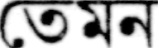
তেমন
